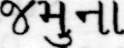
જમુના
